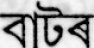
বাটৰ
